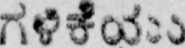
ಗಳಿಕೆಯು
